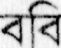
ববি
